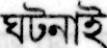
ঘটনাই
